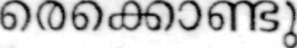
രെക്കൊണ്ടു
